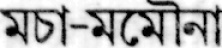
মচা-মমৌনা
